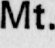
Mt.
